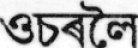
ওচৰলৈ
